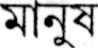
মানুষ
